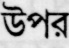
উপর
